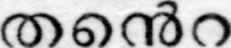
തന്റെ
